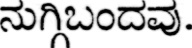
ನುಗ್ಗಿಬಂದವು.
